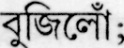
বুজিলোঁ;
